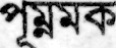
পূম্নমক
